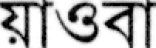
য়াওবা
